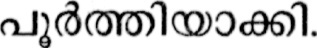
പൂര്‍ത്തിയാക്കി.
